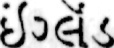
ઇંગ્લૅંડ
